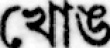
খোঙ
